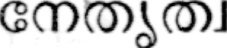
നേതൃത്വ
